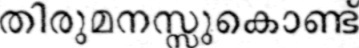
തിരുമനസ്സുകൊണ്ട്
